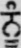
ਨੂੰ
